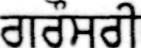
ਗਰੌਸਰੀ
